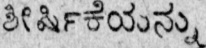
ಶೀರ್ಷಿಕೆಯನ್ನು
